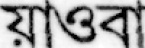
য়াওবা
